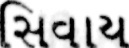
સિવાય
